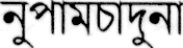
নুপামচাদুনা
